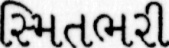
સ્મિતભરી
